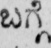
ಬಗ್ಗೆ
